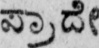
ಪ್ರಾದೇ
